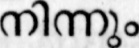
നിന്നും
